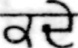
ਕਦੇ
